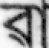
ৱা
